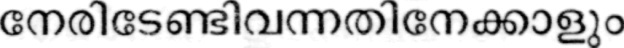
നേരിടേണ്ടിവന്നതിനേക്കാളും
